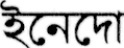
ইনেদো
